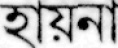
হায়না
